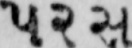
પરસ
